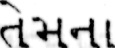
તેમના
